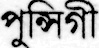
পুন্সিগী
